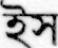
ইস
